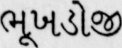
ભૂખડોજી
